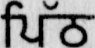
ਪਿੱਠ
